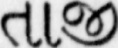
તાજી
